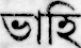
ভাহি
